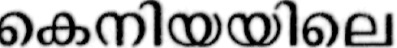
കെനിയയിലെ
